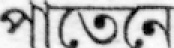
পাতেনে
